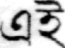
এই
